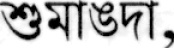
শুমাঙদা,
